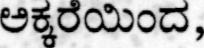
ಅಕ್ಕರೆಯಿಂದ,
